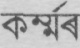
কৰ্ম্মৰ
